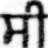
ਸੀ
